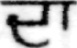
ਦਾ
